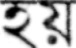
হয়
